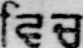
ਵਿਚ
